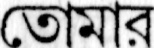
তোমার
